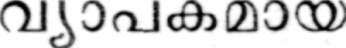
വ്യാപകമായ
